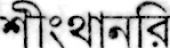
শীংথানরি
